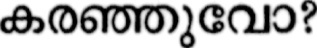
കരഞ്ഞുവോ?
